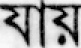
যায়
